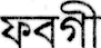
ফবগী
